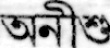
অনীশু
